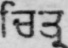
ਚਿਤ੍ਰ
